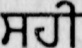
ਸਹੀ
